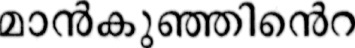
മാന്‍കുഞ്ഞിന്റെ
